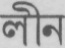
লীন
